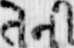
તેની
